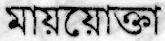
মায়য়োক্তা
